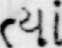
ત્યાં
